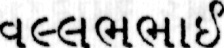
વલ્લભભાઈ
